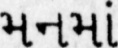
મનમાં
